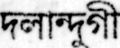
দলান্দুগী
